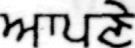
ਆਪਣੇ
